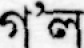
গ'ল
